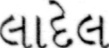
લાદેલ
